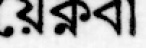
য়েক্নবা
